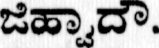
ಜಿಹ್ವಾದೌ.
